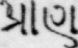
પ્રાણ
